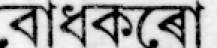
বোধকৰো
